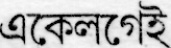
একেলগেই
